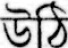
উঠি
